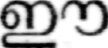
ഈ
